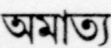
অমাত্য
